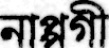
নাপ্পগী
